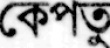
কেপতু
